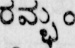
ರಮ್ಭಂ
